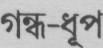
গন্ধ-ধূপ
